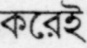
করেই
